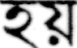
হয়
